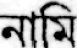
নামি
